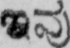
ಇವು
